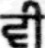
ਵੀ
